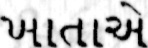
ખાતાએ
